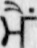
ਮੈਂ
